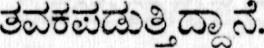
ತವಕಪಡುತ್ತಿದ್ದಾನೆ.
